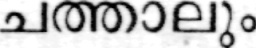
ചത്താലും
